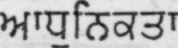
ਆਧੁਨਿਕਤਾ
